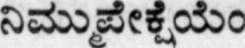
ನಿಮ್ಮುಪೇಕ್ಷೆಯೆಂ
